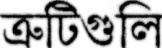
ত্রুটিগুলি
